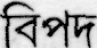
বিপদ
